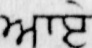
ਆਏ
